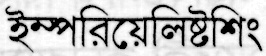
ইস্পরিয়েলিষ্টশিং
